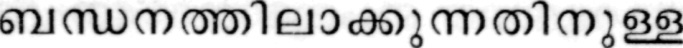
ബന്ധനത്തിലാക്കുന്നതിനുള്ള
